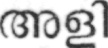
അളി
